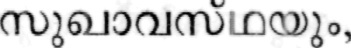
സുഖാവസ്ഥയും,
